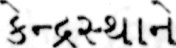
કેન્દ્રસ્થાને
